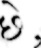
છે,
